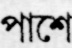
পাশে
